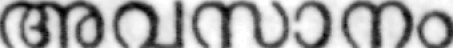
അവസാനം
